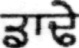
ਡਾਢੇ
